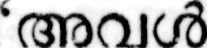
'അവള്‍
